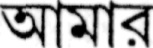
আমার
